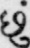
છું
